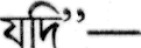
যদি"-
